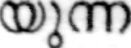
യുന്ന
